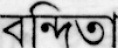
বন্দিতা
